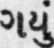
ગયું
